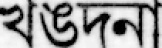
খঙদনা
